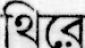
থিরে
